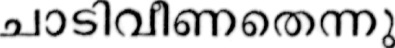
ചാടിവീണതെന്നു
